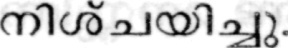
നിശ്ചയിച്ചു.
